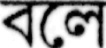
বলে
